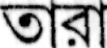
তারা
